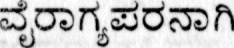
ವೈರಾಗ್ಯಪರನಾಗಿ
